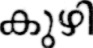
കുഴി
